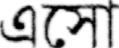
এসো
